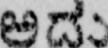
ಅದು
